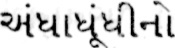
અંધાધૂંધીનો
